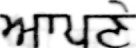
ਆਪਣੇ
